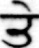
ਤੇ
